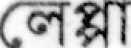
লেপ্পা
